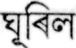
ঘূৰিল
